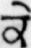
ਕੇ
